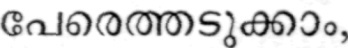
പേരെത്തടുക്കാം,
